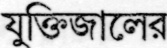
যুক্তিজালের
